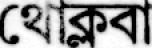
থোক্লবা
